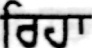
ਰਿਹਾ
